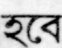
হবে
